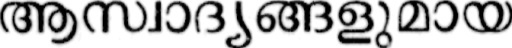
ആസ്വാദ്യങ്ങളുമായ
